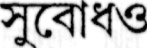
সুবোধও
